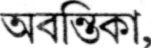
অবন্তিকা,
